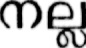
നല്ല
